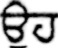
ਉਹ
